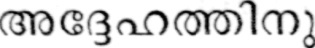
അദ്ദേഹത്തിനു
